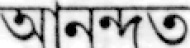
আনন্দত
